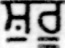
ਸ਼ੁਰੂ
